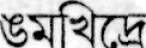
ঙমখিদ্রে
